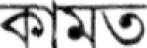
কামত
